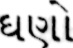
ઘણો
